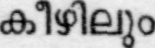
കീഴിലും
